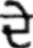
ਦੇ
